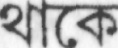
থাকে
